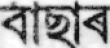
বাছাৰ
